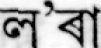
ল'ৰা
